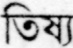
তিষ্য
